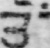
ਤੋਂ
